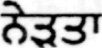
ਨੇੜਤਾ
